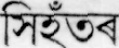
সিহঁতৰ
